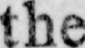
the
